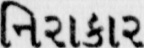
નિરાકાર
